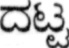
ದಟ್ಟ
